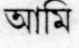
আমি
